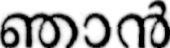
ഞാന്‍
